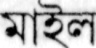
মাইল
